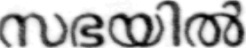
സഭയില്‍
